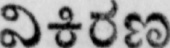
ವಿಕಿರಣ
